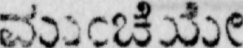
ಮುಂಚೆಯೇ
